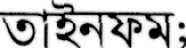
তাইনফম;
